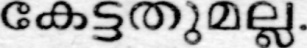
കേട്ടതുമല്ല.
